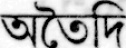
অতৈদি
